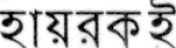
হায়রকই
